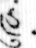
હું.
